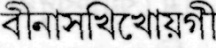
বীনাসখিখোয়গী
